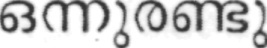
ഒന്നുരണ്ടു
